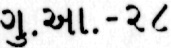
ગુ.આ.-૨૮
